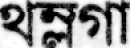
থম্লগা
